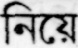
নিয়ে
